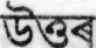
উত্তৰ
